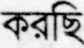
করছি
